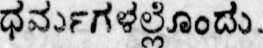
ಧರ್ಮಗಳಲ್ಲೊಂದು.
